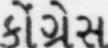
કોંગ્રેસ
